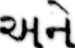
અને
